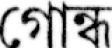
গোন্ধ
